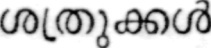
ശത്രുക്കള്‍
